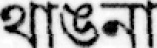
থাঙনা
